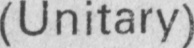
(Unitary)
